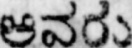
ಅವರು
